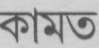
কামত
